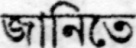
জানিতে
